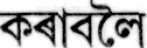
কৰাবলৈ
